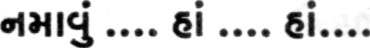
નમાવું......હાં......હાં........
